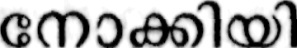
നോക്കിയി
